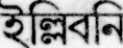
ইল্লিবনি
